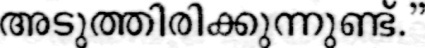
അടുത്തിരിക്കുന്നുണ്ട്.”
